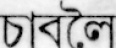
চাবলৈ
